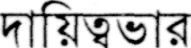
দায়িত্বভার
